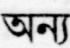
অন্য
